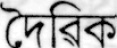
দৈৱিক
